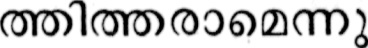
ത്തിത്തരാമെന്നു
